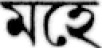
মহে
